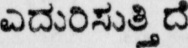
ಎದುರಿಸುತ್ತಿದೆ
